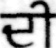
ਦੀ
